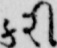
કરી
